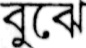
বুঝে
